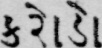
કરોડો
